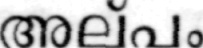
അല്പം
